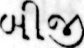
બીજી
